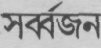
সৰ্ব্বজন
